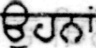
ਉਹਨਾਂ
